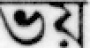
ভয়
